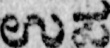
ಉಪ
